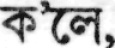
ক'লে,
